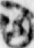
છે
